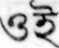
ওই
